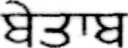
ਬੇਤਾਬ
